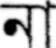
না
